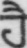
ਹੈ
